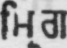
ਮ੍ਰਿਗ
